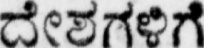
ದೇಶಗಳಿಗೆ
